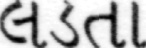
લડતા
